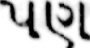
પણ
